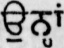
ਉਨ੍ਹਾਂ
